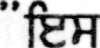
''ਇਸ
